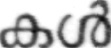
കള്‍
